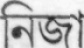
নিজা
